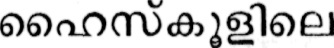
ഹൈസ്കൂളിലെ
